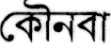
কৌনবা
